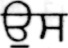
ਉਸ
